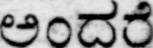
ಅಂದರೆ
